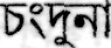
চংদুনা
